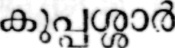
കുപ്പശ്ശാര്‍
